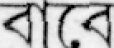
বাবে
